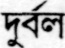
দুর্বল
